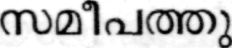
സമീപത്തു
